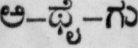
ಅ-ಥೈ-ಗು
